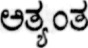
ಅತ್ಯಂತ
